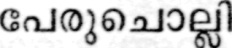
പേരുചൊല്ലി
